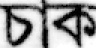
চাক
